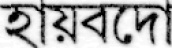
হায়বদো
